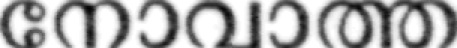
നോവാത്ത
